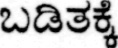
ಬಡಿತಕ್ಕೆ
